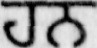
ਹਨ
